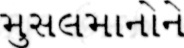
મુસલમાનોને
